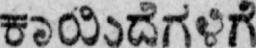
ಕಾಯಿದೆಗಳಿಗೆ
